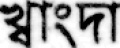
খ্বাংদা
